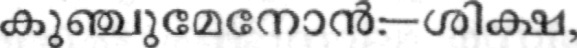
കുഞ്ചുമേനോന്‍:-ശിക്ഷ,
